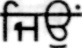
ਜਿਉਂ
